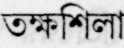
তক্ষশিলা
